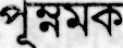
পূম্নমক
